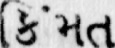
કિંમત
